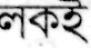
লকই
